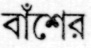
বাঁশের
